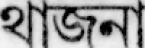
থাজনা
